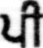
ਪੀ
